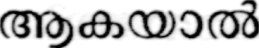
ആകയാല്‍
